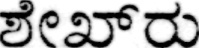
ಶೇಖ್ ರು
